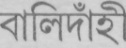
বালিদাঁহী
